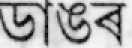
ডাঙৰ
